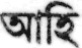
আহি
